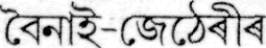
বৈনাই-জেঠেৰীৰ
